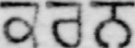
ਕਰਨ
